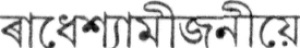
ৰাধেশ্যামীজনীয়ে
